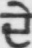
ਦੇ
